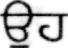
ਉਹ
